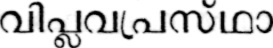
വിപ്ലവപ്രസ്ഥാ
